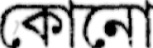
কোনো
